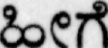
ಹೀಗೆ
